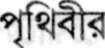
পৃথিবীর
